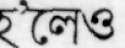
হ'লেও
